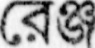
রেঞ্জ
